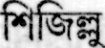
শিজিল্লু
